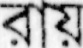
রায়
